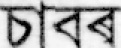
চাবৰ
